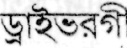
ড্রাইভরগী
